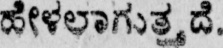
ಹೇಳಲಾಗುತ್ತದೆ.
